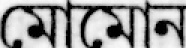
মোমোন
